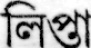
লিপ্তা
